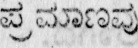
ಪ್ರಮಾಣವು
